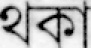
থকা
